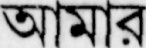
আমার
